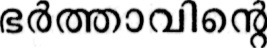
ഭര്‍ത്താവിന്റെ
